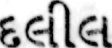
દલીલ
